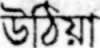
উঠিয়া
